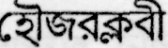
হৌজরক্লবী
